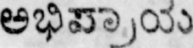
ಅಭಿಪ್ರಾಯ
